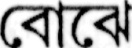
বোঝে
